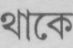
থাকে
